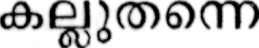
കല്ലുതന്നെ
